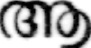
ആ
